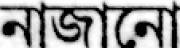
নাজানো
